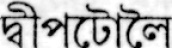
দ্বীপটোলৈ
